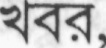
খবর,
